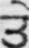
ਤੇ
